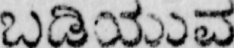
ಬಡಿಯುವ
